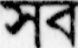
সব
